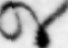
જ
